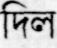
দিল
